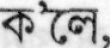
ক'লে,
